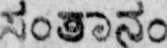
ಸಂತಾನಂ
